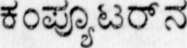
ಕಂಪ್ಯೂಟರ್‌ನ
